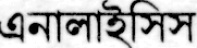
এনালাইসিস
